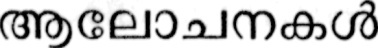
ആലോചനകള്‍
